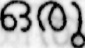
ഒരു
